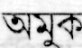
অমুক
